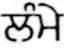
ਲੰਮੇ
